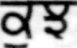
ਕੁਝ
